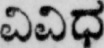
ವಿವಿಧ
